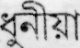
ধুনীয়া
